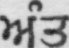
ਅੰਤ
